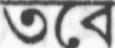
তবে
